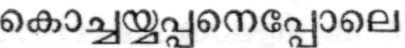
കൊച്ചയ്യപ്പനെപ്പോലെ
